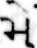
મેં
